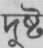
দুষ্ট
